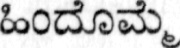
ಹಿಂದೊಮ್ಮೆ
